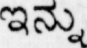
ಇನ್ನು
